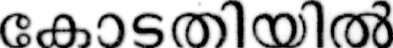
കോടതിയില്‍
